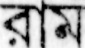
রাম
